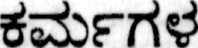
ಕರ್ಮಗಳ
